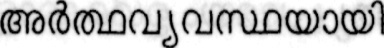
അര്‍ത്ഥവ്യവസ്ഥയായി
